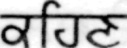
ਕਹਿਣ
